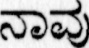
ನಾವು
